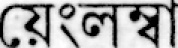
য়েংলম্বা
